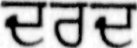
ਦਰਦ
